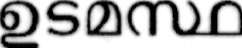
ഉടമസ്ഥ
